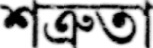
শত্রুতা
